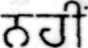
ਨਹੀਂ
